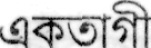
একতাগী
